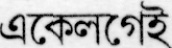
একেলগেই
